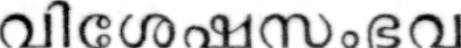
വിശേഷസംഭവ
